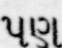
પણ
